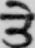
ਤੇ
